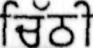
ਚਿੱਠੀ
